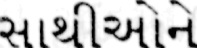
સાથીઓને
